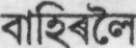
বাহিৰলৈ
